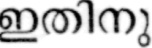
ഇതിനു
